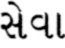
સેવા
